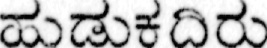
ಹುಡುಕದಿರು
